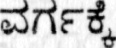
ವರ್ಗಕ್ಕೆ
